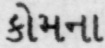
કોમના
